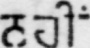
ਨਹੀਂ
